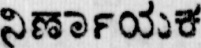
ನಿರ್ಣಾಯಕ
